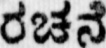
ರಚನೆ
